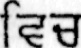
ਵਿਚ
